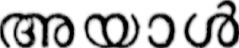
അയാള്‍
